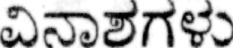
ವಿನಾಶಗಳು
